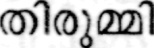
തിരുമ്മി
